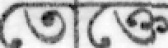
তোক্তে
